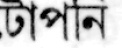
টোপনি
